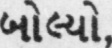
બોલ્યો,
